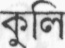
কুলি
